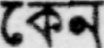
কেন
